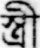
স্ত্রী
